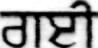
ਗਈ
